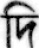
দি
